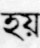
হয়
